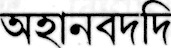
অহানবদদি
